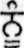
ਨੂੰ
